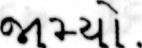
જામ્યો.
